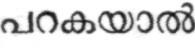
പറകയാല്‍
